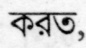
করত,
